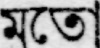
মতো
